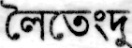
লৈতেংদু
